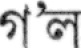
গ'ল
